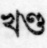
খণ্ড
